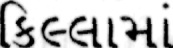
કિલ્લામાં
